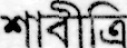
শাবীত্রি
